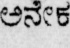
ಅನೇಕ
